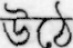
উঠে
